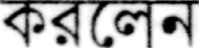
করলেন
